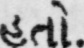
હતો.
